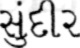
સુંદીર
